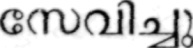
സേവിച്ചു
